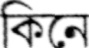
কিনে
